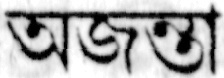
অজন্তা
